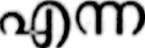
എന്ന
